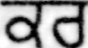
ਕਰ
